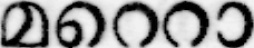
മറെറാ
